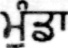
ਮੁੰਡਾ
